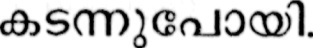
കടന്നുപോയി.
